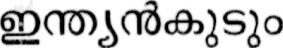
ഇന്ത്യന്‍കുടും
